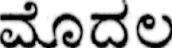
ಮೊದಲ
